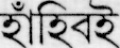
হাঁহিবই
